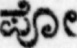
ಪೋ
